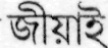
জীয়াই
